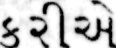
કરીએ
